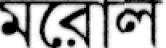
মরোল
